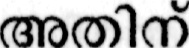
അതിന്
